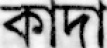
কাদা
